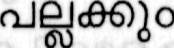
പല്ലക്കും
